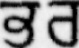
ਭਰ
